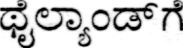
ಥೈಲ್ಯಾಂಡ್ ಗೆ
